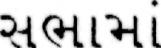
સભામાં
